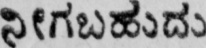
ನೀಗಬಹುದು
